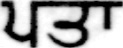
ਪਤਾ
